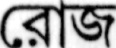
রোজ
